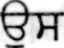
ਉਸ
